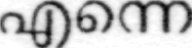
എന്നെ
